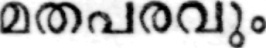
മതപരവും
